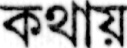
কথায়
